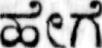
ಹೇಗೆ
